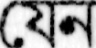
যেন
